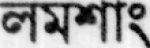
লমশাং
